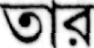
তার
